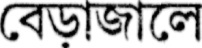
বেড়াজালে
